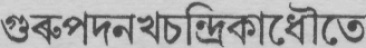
গুৰুপদনখচন্দ্ৰিকাধৌতে
